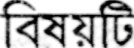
বিষয়টি
